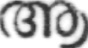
ആ
